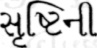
સૃષ્ટિની
